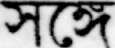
সঙ্গে
